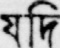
যদি
